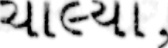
ચાલ્યા,
